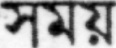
সময়
